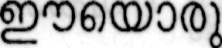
ഈയൊരു
